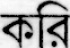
করি
